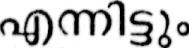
എന്നിട്ടും
